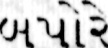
બપોરે
